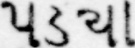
પડ્યા
